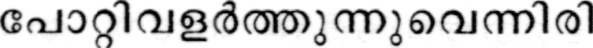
പോറ്റിവളര്‍ത്തുന്നുവെന്നിരി
